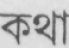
কথা
